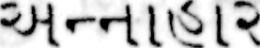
અન્નાહાર
